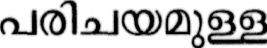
പരിചയമുള്ള
